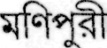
মণিপুরী
